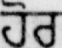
ਹੋਰ
